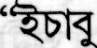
“ইচাবু
